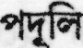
পদূলি
